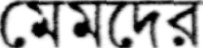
মেমদের
